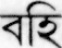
বহি
